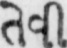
તેવી
